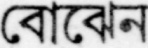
বোঝেন
